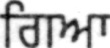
ਗਿਆ
